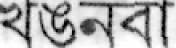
খঙনবা
